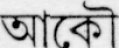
আকৌ
